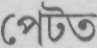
পেটত
